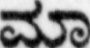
ಮಾ
